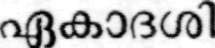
ഏകാദശി
